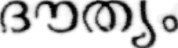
ദൌത്യം
